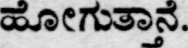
ಹೋಗುತ್ತಾನೆ.
